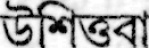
উশিত্তবা
